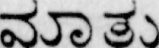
ಮಾತು
